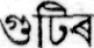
গুটিৰ
